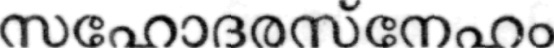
സഹോദരസ്നേഹം
